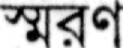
স্মরণ
